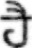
ਹੈ
